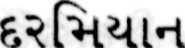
દરમિયાન
